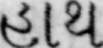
હાથ
